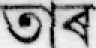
তাৰ
